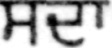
ਸਦਾ
